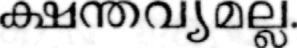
ക്ഷന്തവ്യമല്ല.
